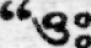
“ওঃ
